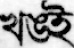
খঙই
